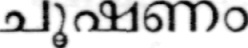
ചൂഷണം
